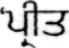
'ਪ੍ਰੀਤ
